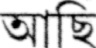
আছি
